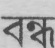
বন্ধ
